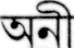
অনী
